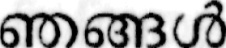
ഞങ്ങള്‍
